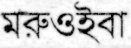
মরুওইবা
